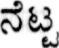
ನೆಟ್ಟ
